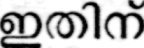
ഇതിന്
